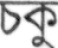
চকু
